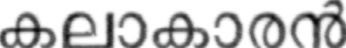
കലാകാരന്‍
